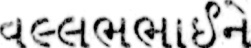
વલ્લભભાઈને
